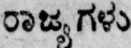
ರಾಜ್ಯಗಳು
